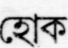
হোক
